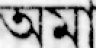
অমা
